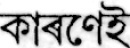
কাৰণেই
